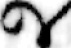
જ
